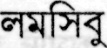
লমসিবু
